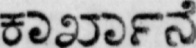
ಕಾರ್ಖಾನೆ
